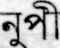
নুপী
